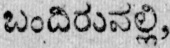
ಬಂದಿರುವಲ್ಲಿ,
